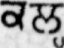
ਕਲ੍ਹ
